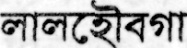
লালহৌবগা
